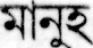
মানুহ
